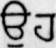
ਉਹ
